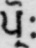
ਪ੍ਰੋ:
